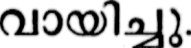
വായിച്ചു.
